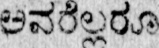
ಅವರೆಲ್ಲರೂ
